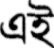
এই
